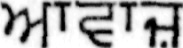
ਆਵਾਜ਼
